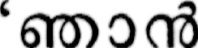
'ഞാന്‍
